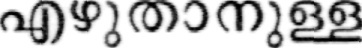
എഴുതാനുള്ള
